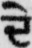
ਦੇ
